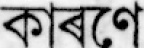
কাৰণে
